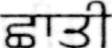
ਛਾਤੀ
